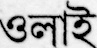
ওলাই
